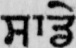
ਸਾਡੇ
